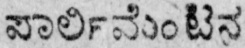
ಪಾರ್ಲಿಮೆಂಟಿನ
